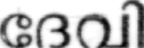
ദേവി
